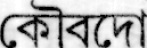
কৌবদো
